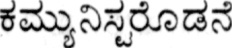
ಕಮ್ಯುನಿಸ್ಟರೊಡನೆ
